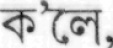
ক'লে,
